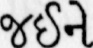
જઈને
